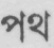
পথ
